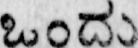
ಒಂದು
